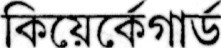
কিয়ের্কেগার্ড
